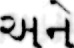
અને
